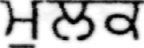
ਮੁਲਕ
